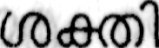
ശക്തി
